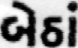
બેઠાં
